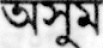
অসুম
